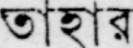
তাহার
